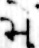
મેં
